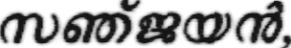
സഞ്ജയന്‍,
